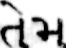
તેમ
